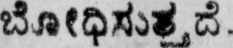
ಬೋಧಿಸುತ್ತದೆ.
